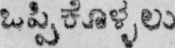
ಒಪ್ಪಿಕೊಳ್ಳಲು
